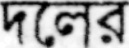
দলের
